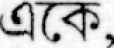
একে,
